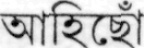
আহিছোঁ
